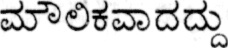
ಮೌಲಿಕವಾದದ್ದು
